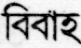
বিবাহ
